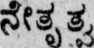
ನೇತೃತ್ವ
